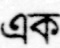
এক
